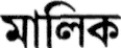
মালিক
